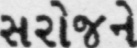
સરોજને
